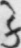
કે
